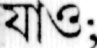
যাও;
